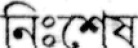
নিঃশেষ
